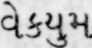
વેક્યુમ
